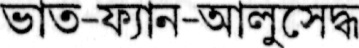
ভাত-ফ্যান-আলুসেদ্ধ
